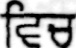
ਵਿਚ
